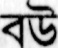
বউ
